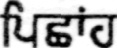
ਪਿਛਾਂਹ
